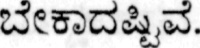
ಬೇಕಾದಷ್ಟಿವೆ.
